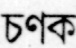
চণক
